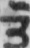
ਤੋ
